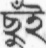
ছুঁই
